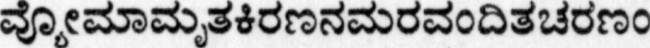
ವ್ಯೋಮಾಮೃತಕಿರಣನಮರವಂದಿತಚರಣಂ
